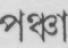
পঞ্চা
